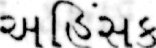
અહિંસક
